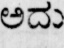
ಅದು
